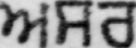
ਅਸਰ
